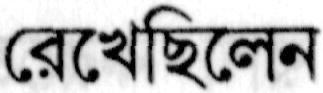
রেখেছিলেন
